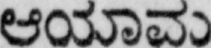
ಆಯಾಮ
